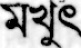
মখুৎ
